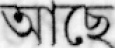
আছে
